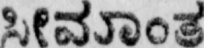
ಸೀಮಾಂತ
